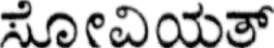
ಸೋವಿಯತ್
